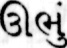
ઊભું
